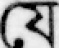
যে
